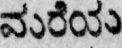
ಮರೆಯ
